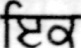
ਇਕ
